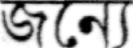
জন্যে
